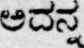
ಅದನ್ನ
